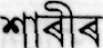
শাৰীৰ
